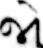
જો
